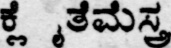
ಕ್ಲೈತೆಮೆಸ್ತ್ರ
